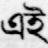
এই
